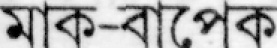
মাক-বাপেক
